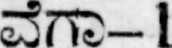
ವೆಗಾ-1
